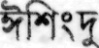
ঈশিংদু
